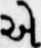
એ
